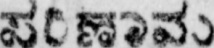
ಪರಿಣಾಮ
